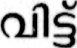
വിട്ട്
